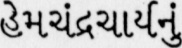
હેમચંદ્રચાર્યનું
